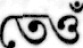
তেওঁ
